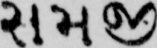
સમજી
